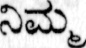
ನಿಮ್ಮ
